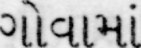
ગોવામાં
